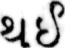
થઈ
